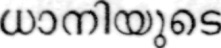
ധാനിയുടെ
